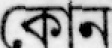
কোন
